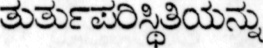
ತುರ್ತುಪರಿಸ್ಥಿತಿಯನ್ನು
